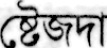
ষ্টেজদা
